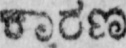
ಕಾರಣ
